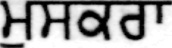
ਮੁਸਕਰਾ
